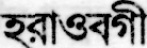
হরাওবগী
